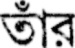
তাঁর
